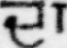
ਦਾ
